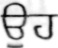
ਉਹ
